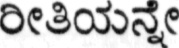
ರೀತಿಯನ್ನೇ
